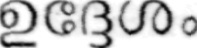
ഉദ്ദേശം
